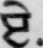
ਏ.
